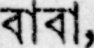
বাবা,
